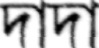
দাদা
